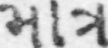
માત્ર
